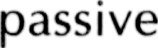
passive
